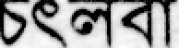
চৎলবা
